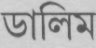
ডালিম
